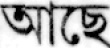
আছে
